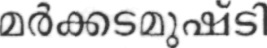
മര്‍ക്കടമുഷ്ടി
